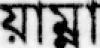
য়াম্না
